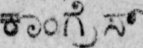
ಕಾಂಗ್ರೆಸ್
